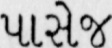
પાસેજ
